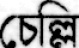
চেল্লি
